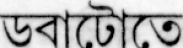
ডবাটোতে
